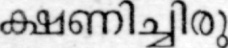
ക്ഷണിച്ചിരു
